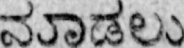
ಮಾಡಲು
